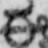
ಈ
